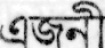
এজনী
